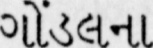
ગોંડલના
